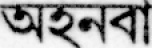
অহনবা
